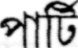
পার্টি
